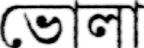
ভোলা
